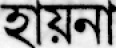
হায়না
